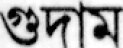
গুদাম
